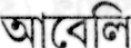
আবেলি
